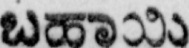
ಬಹಾಯಿ
